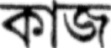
কাজ
